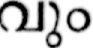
വും
